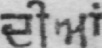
ਦੀਆਂ
